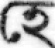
হে
